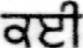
ਕਈ
